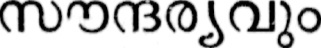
സൌന്ദര്യവും
